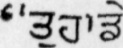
''ਤੁਹਾਡੇ
